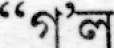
"গ'ল
